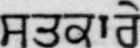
ਸਤਕਾਰੇ
